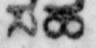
ಸಹ
